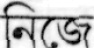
নিজে
